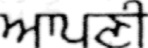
ਆਪਣੀ
